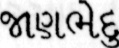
જાણભેદુ
